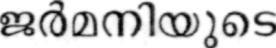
ജര്‍മനിയുടെ
